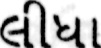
લીધા
